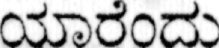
ಯಾರೆಂದು
